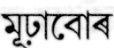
মূঢ়াবোৰ
